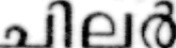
ചിലര്‍
